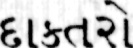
દાક્તરો
